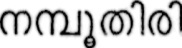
നമ്പൂതിരി
